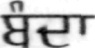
ਬੰਦਾ
